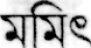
মমিৎ
